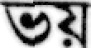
ভয়
